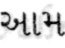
આમ
